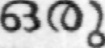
ഒരു
